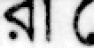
খরা
